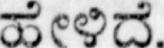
ಹೇಳಿದೆ.
